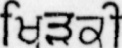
ਖਿੜਕੀ
